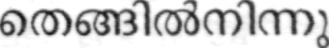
തെങ്ങില്‍നിന്നു
